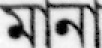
মানা
